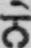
ਨੇ
